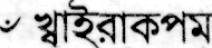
ঁখ্বাইরাকপম
